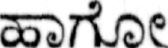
ಹಾಗೋ
